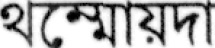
থম্মোয়দা
